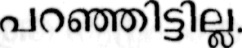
പറഞ്ഞിട്ടില്ല.
